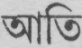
আতি
